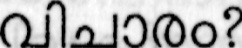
വിചാരം?
